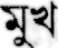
মুখ
